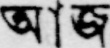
আজ
